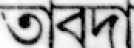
তাবদা
